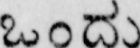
ಒಂದು
